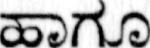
ಹಾಗೂ
